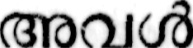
അവള്‍
